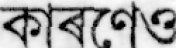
কাৰণেও
